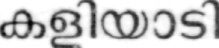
കളിയാടി
